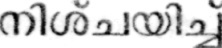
നിശ്ചയിച്ച്
